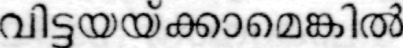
വിട്ടയയ്ക്കാമെങ്കില്‍
